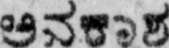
ಅವಕಾಶ
